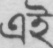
এই
